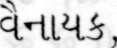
વૈનાયક,
